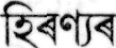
হিৰণ্যৰ
